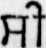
ਸੀ
